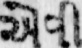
એવી
